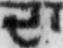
ਦਾ
